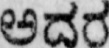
ಅದರ
